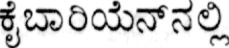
ಕೈಬಾರಿಯೆನ್ನಲ್ಲಿ
